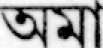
অমা
